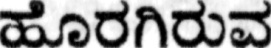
ಹೊರಗಿರುವ
